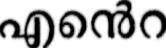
എന്റെ
